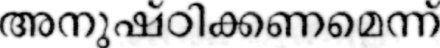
അനുഷ്ഠിക്കണമെന്ന്
